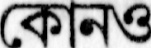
কোনও
